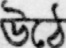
উঠে
